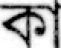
কা
